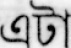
এটা
